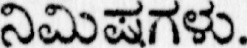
ನಿಮಿಷಗಳು.
